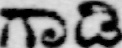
ಗಾಡಿ
